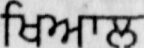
ਖਿਆਲ
